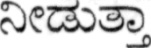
ನೀಡುತ್ತಾ
